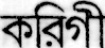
করিগী
